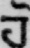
ਹੋ
